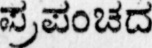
ಪ್ರಪಂಚದ
